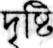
দৃষ্টি
